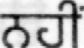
ਨਹੀਂ
